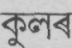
কুলৰ
